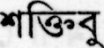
শক্তিবু
